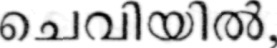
ചെവിയില്‍,
